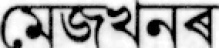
মেজখনৰ
